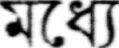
মধ্যে
